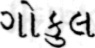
ગોકુલ
